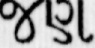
જણ
